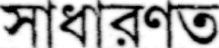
সাধারণত
